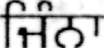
ਜਿੰਨਾ
